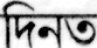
দিনত
